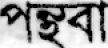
পন্থবা
